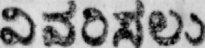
ವಿವರಿಸಲು
